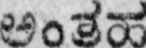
ಅಂತಹ
